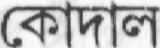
কোদাল
